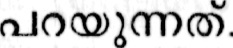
പറയുന്നത്.
